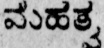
ಮಹತ್ವ
